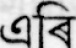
এৰি
